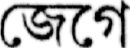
জেগে
